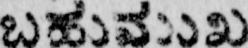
ಬಹುಮುಖ
